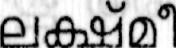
ലക്ഷ്മീ
